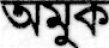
অমুক
